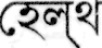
হেলথ
